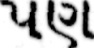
પણ
